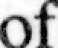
of
